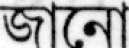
জানো
